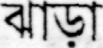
ঝাড়া
